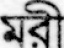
মরী
